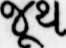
જૂથ
